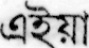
এইয়া
